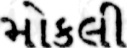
મોકલી
